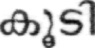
കൂടി
